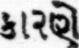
કારણે
